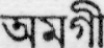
অমগী
